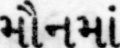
મૌનમાં
